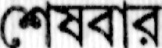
শেষবার
